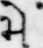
મેં
